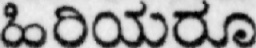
ಹಿರಿಯರೂ
